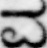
ವ
